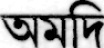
অমদি
